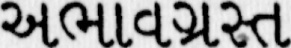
અભાવગ્રસ્ત
